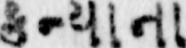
કન્યાના
